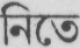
নিতে
